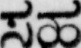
ಸಹ
